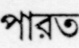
পারত
